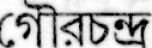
গৌরচন্দ্র
